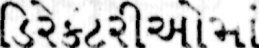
ડિરેક્ટરીઓમાં
